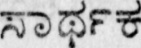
ಸಾರ್ಥಕ
